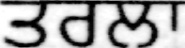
ਤਰਲਾ
